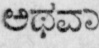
ಅಥವಾ
